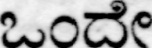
ಒಂದೇ
